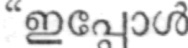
“ഇപ്പോള്‍
